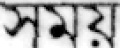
সময়
